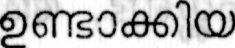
ഉണ്ടാക്കിയ
